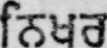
ਨਿਖਰ
